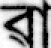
ৱা
